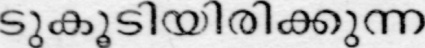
ടുകൂടിയിരിക്കുന്ന
